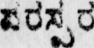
ಪರಸ್ಪರ
